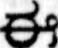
ಈ
